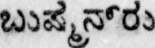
ಬುಷ್ಮನ್ರು
